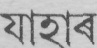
যাহাৰ
